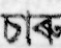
চাৰু
